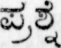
ಪ್ರಶ್ನೆ
